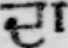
ਦਾ
